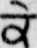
ਕੇ
